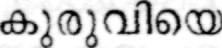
കുരുവിയെ
